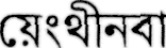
য়েংথীনবা
